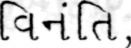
વિનંતિ,
